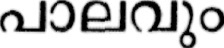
പാലവും
